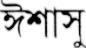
ঈশাসু
